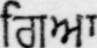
ਗਿਆ
